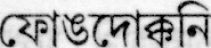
ফোঙদোক্কনি
